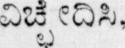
ವಿಚ್ಛೇದಿಸಿ,
